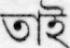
তাই
